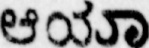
ಆಯಾ
